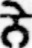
ਨੇ
